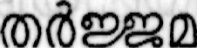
തര്‍ജ്ജമ
